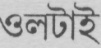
ওলটাই
